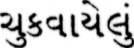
ચુકવાયેલું
